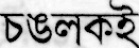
চঙলকই
